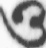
ও
